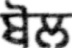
ਬੋਲ
